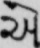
એ
